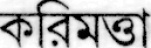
করিমত্তা
